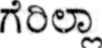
ಗೆರಿಲ್ಲಾ
